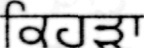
ਕਿਹੜਾ
